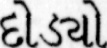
દોડ્યો
